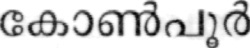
കോണ്‍പൂര്‍
